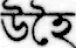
উহৈ
